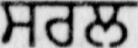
ਸਰਲ
